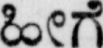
ಹೀಗೆ
